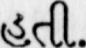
હતી.
